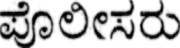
ಪೊಲೀಸರು
